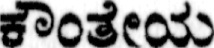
ಕೌಂತೇಯ
